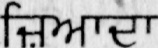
ਜ਼ਿਆਦਾ
